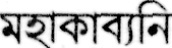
মহাকাব্যনি
